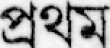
প্রথম
